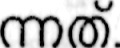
ന്നത്.
